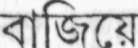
বাজিয়ে
